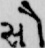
સૌ
